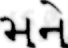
મને
